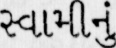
સ્વામીનું
